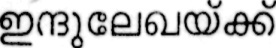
ഇന്ദുലേഖയ്ക്ക്
